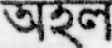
অহল
